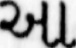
આ
